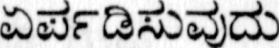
ಏರ್ಪಡಿಸುವುದು
